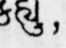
કહ્યું,'
